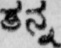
ತನ್ನ
